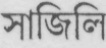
সাজিলি
